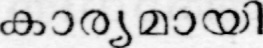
കാര്യമായി
